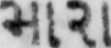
મારા
